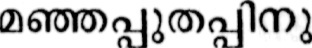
മഞ്ഞപ്പുതപ്പിനു
